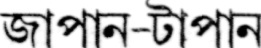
জাপান-টাপান
